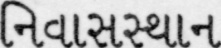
નિવાસસ્થાન
